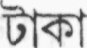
টাকা
